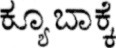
ಕ್ಯೂಬಾಕ್ಕೆ
